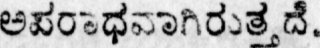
ಅಪರಾಧವಾಗಿರುತ್ತದೆ.
